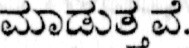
ಮಾಡುತ್ತವೆ.
